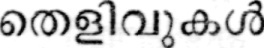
തെളിവുകള്‍
